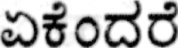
ಏಕೆಂದರೆ
